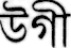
উগী
